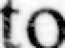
to
